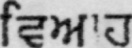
ਵਿਆਹ
